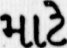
માટે
